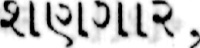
શણગાર,
